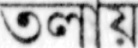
তলায়
